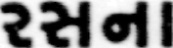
રસના
